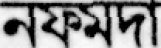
নফমদা
